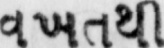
વખતથી
